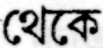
থেকে
